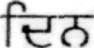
ਦਿਨ
